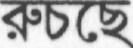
রুচছে
